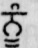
ਨੂੰ
